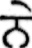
ਨੇ
